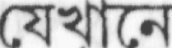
যেখানে
